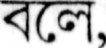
বলে,
